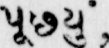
પૂછ્યું,
